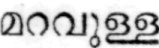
മറവുള്ള
